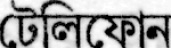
টেলিফোন
